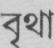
বৃথা
